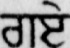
ਗਏ
